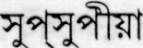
সুপসুপীয়া
